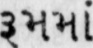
રૂમમાં
